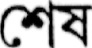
শেষ
